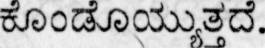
ಕೊಂಡೊಯ್ಯುತ್ತದೆ.
